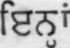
ਇਨ੍ਹਾਂ
